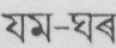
যম-ঘৰ
